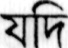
যদি
